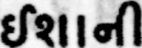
ઈશાની
